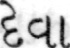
દેવા
